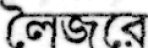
লৈজরে
